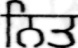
ਨਿਤ
